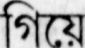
গিয়ে
